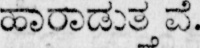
ಹಾರಾಡುತ್ತವೆ.
